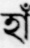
হাঁ
